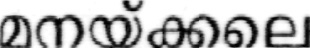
മനയ്ക്കലെ
